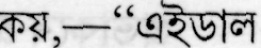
কয়,-"এইডাল
